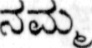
ನಮ್ಮ
